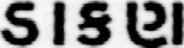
ડાકણ
